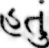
હતું
